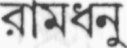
রামধনু
